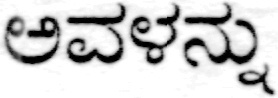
ಅವಳನ್ನು
